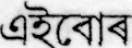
এইবোৰ
